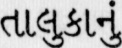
તાલુકાનું
